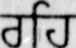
ਰਹਿ
